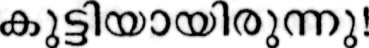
കുട്ടിയായിരുന്നു!
